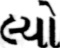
લ્યો
